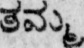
ತಮ್ಮ
